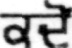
ਕਦੋਂ
